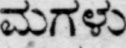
ಮಗಳು
